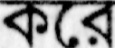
করে
